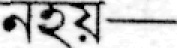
নহয়-
